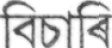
বিচাৰি
